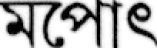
মপোৎ
